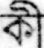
কী
